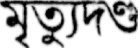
মৃত্যুদণ্ড
